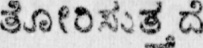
ತೋರಿಸುತ್ತದೆ
